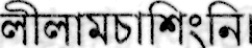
লীলামচাশিংনি।
